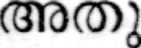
അതു
